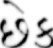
છેક
